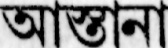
আস্তানা
